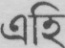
এহি
